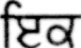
ਇਕ
